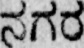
ನಗರ
